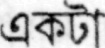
একটা
